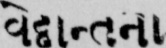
વેદાન્તના
